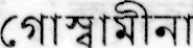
গোস্বামীনা
